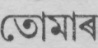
তোমাৰ
